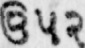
ઉપર
